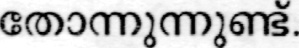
തോന്നുന്നുണ്ട്.
